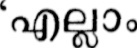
‘എല്ലാം
